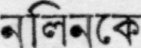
নলিনকে
